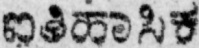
ಐತಿಹಾಸಿಕ
